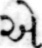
એ
